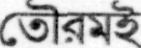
তৌরমই
